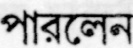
পারলেন
